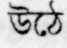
উঠে
